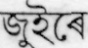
জুইৰে
